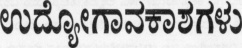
ಉದ್ಯೋಗಾವಕಾಶಗಳು
